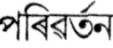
পৰিৱর্তন
